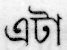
এটা
